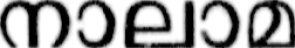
നാലാമ
